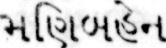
મણિબહેન
